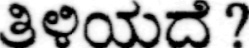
ತಿಳಿಯದೆ?
